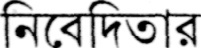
নিবেদিতার
